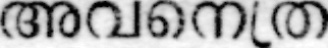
അവനെത്ര
